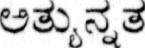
ಅತ್ಯುನ್ನತ
